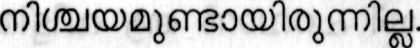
നിശ്ചയമുണ്ടായിരുന്നില്ല.
